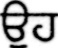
ਉਹ
